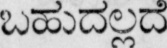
ಬಹುದಲ್ಲದೆ
